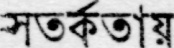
সতর্কতায়
